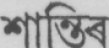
শান্তিৰ
